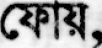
ফোয়,
